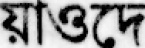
য়াওদে
